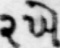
રખે
